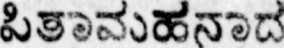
ಪಿತಾಮಹನಾದ
